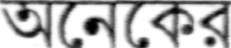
অনেকের
